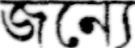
জন্যে
